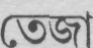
তেজা
